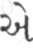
એ
